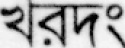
খরদং
